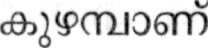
കുഴമ്പാണ്
